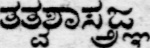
ತತ್ವಶಾಸ್ತ್ರಜ್ಞ
